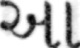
આ
